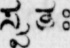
ಸ್ವತಃ
